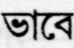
ভাবে
